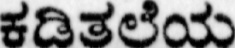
ಕಡಿತಲೆಯ
